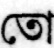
তো
